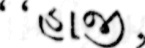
"હાજી,
